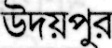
উদয়পুর
